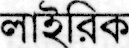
লাইরিক
